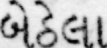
બેઠેલા
